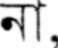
না,
